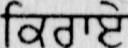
ਕਿਰਾਏ
